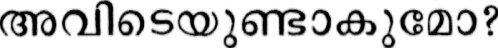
അവിടെയുണ്ടാകുമോ?
